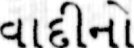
વાદીનો
